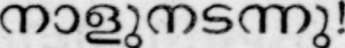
നാളുനടന്നു!
